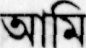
আমি
